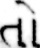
તો
